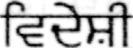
ਵਿਦੇਸ਼ੀ
